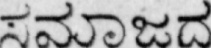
ಸಮಾಜದ
